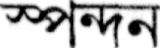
স্পন্দন
